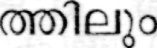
ത്തിലും
